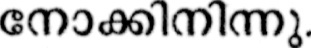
നോക്കിനിന്നു.
